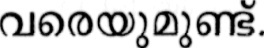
വരെയുമുണ്ട്.
